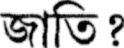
জাতি?
